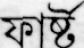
ফার্ষ্ট
